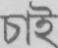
চাই
